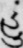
હું
